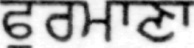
ਫੁਰਮਾਣਾ
